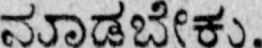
ಮಾಡಬೇಕು.
